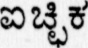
ಐಚ್ಛಿಕ
